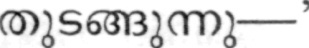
തുടങ്ങുന്നു-'
